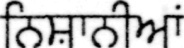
ਨਿਸ਼ਾਨੀਆਂ
